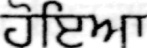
ਹੋਇਆ
